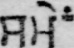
ਸਮੇਂ
